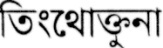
তিংথোক্তুনা
